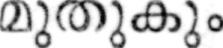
മുതുകും
